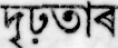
দৃঢ়তাৰ
